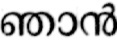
ഞാന്‍
